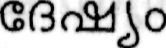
ദേഷ്യം
